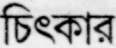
চিত্কার
